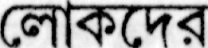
লোকদের
